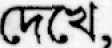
দেখে,
